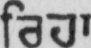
ਰਿਹਾ
